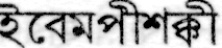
ইবেমপীশক্কী
